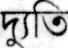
দ্যুতি
